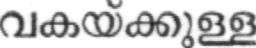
വകയ്ക്കുള്ള
